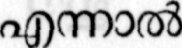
എന്നാല്‍
